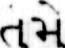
તમે
